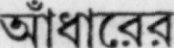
আঁধারের
